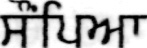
ਸੌਂਪਿਆ
